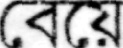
বেয়ে
